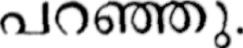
പറഞ്ഞു.
